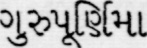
ગુરુપૂર્ણિમા
